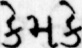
કેમકે
